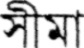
সীমা
